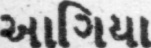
આગિયા
